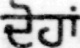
ਦੋਹਾਂ
